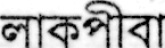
লাকপীবা
